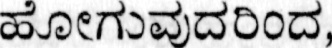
ಹೋಗುವುದರಿಂದ,
